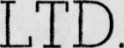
LTD.
